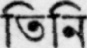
তিনি
